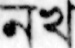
নখ
